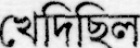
খেদিছিল
